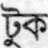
টুক
